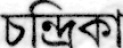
চন্দ্রিকা
